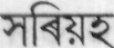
সৰিয়হ
